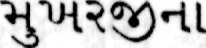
મુખરજીના
